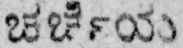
ಚರ್ಚೆಯ
